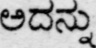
ಅದನ್ನು
